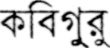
কবিগুরু
